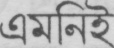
এমনিই
